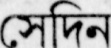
সেদিন
